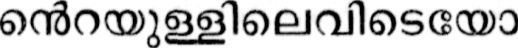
ന്റെയുള്ളിലെവിടെയോ
